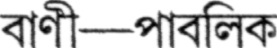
বাণী–পাবলিক
